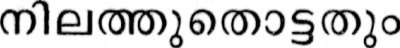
നിലത്തുതൊട്ടതും
